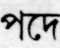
পদে
